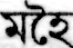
মহৈ
